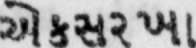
એકસરખા
